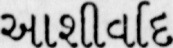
આશીર્વાદ
